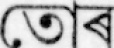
তোৰ
